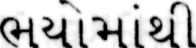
ભયોમાંથી
